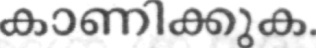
കാണിക്കുക.
